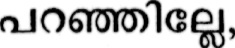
പറഞ്ഞില്ലേ,
